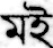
মই
